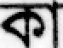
কা
